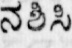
ನಶಿಸಿ
